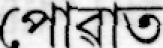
পোৱাত
